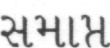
સમાપ્ત
